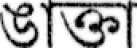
ঙাক্তা
